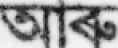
আৰু
